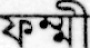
ফম্মী
